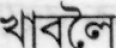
খাবলৈ
